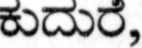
ಕುದುರೆ,
